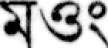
মওং
